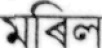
মৰিল
